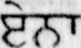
ਏਨਾ
